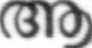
ആ
